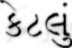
કેટલું
